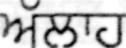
ਅੱਲਾਹ
